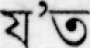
য'ত
